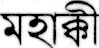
মহাক্কী
